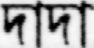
দাদা
